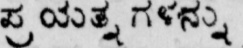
ಪ್ರಯತ್ನಗಳನ್ನು
